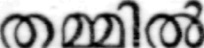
തമ്മില്‍
